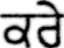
ਕੇਰਾ
